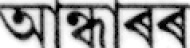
আন্ধাৰৰ
